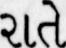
રાતે
